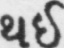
થઈ
